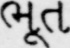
ભૂત
